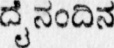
ದೈನಂದಿನ
